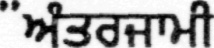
''ਅੰਤਰਜਾਮੀ
